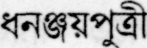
ধনঞ্জয়পুত্রী
